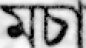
মচা
